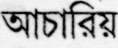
আচারিয়
